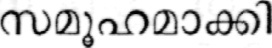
സമൂഹമാക്കി
